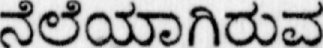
ನೆಲೆಯಾಗಿರುವ
